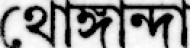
থোঙ্গান্দা
